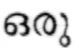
ഒരു
